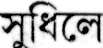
সুধিলে
